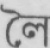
লৈ
